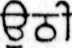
ਉਠੀ
